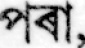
পৰা,
